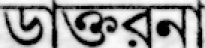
ডাক্তরনা
